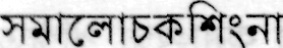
সমালোচকশিংনা
